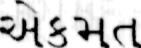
એકમત
